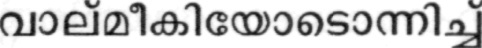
വാല്മീകിയോടൊന്നിച്ച്
